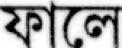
ফালে
